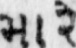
મારે
